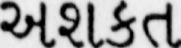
અશકત
